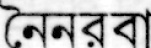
নৈনরবা
